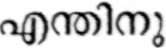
എന്തിനു
